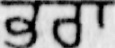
ਭਰਾ
